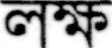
লক্ষ
